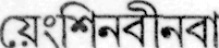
য়েংশিনবীনবা
